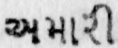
અમારી
